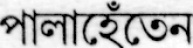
পালাহেঁতেন
